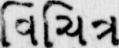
વિચિત્ર
